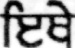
ਇਥੇ
